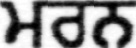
ਮਰਨ
